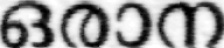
ഒരാന
